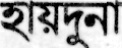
হায়দুনা
